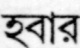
হবার
